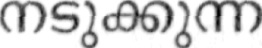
നടുക്കുന്ന
